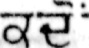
ਕਦੋਂ
